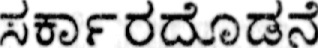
ಸರ್ಕಾರದೊಡನೆ
